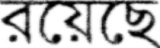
রয়েছে
